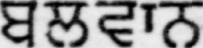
ਬਲਵਾਨ
